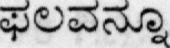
ಫಲವನ್ನೂ
